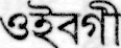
ওইবগী
